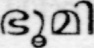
ഭൂമി
